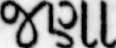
જણા
